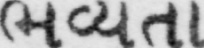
ભવ્યતા
